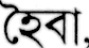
হৈবা,
